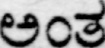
ಅಂತ
